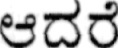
ಆದರೆ
